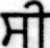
ਸੀ
